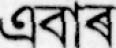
এবাৰ
